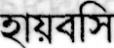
হায়বসি
